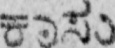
ಕಾಸು
